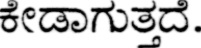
ಕೇಡಾಗುತ್ತದೆ.
